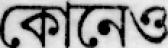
কোনেও
